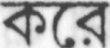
করে
